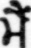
ਮੈਂ
